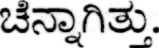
ಚೆನ್ನಾಗಿತ್ತು.
